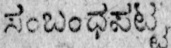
ಸಂಬಂಧಪಟ್ಟ
